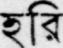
হরি
